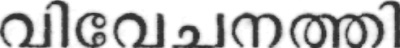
വിവേചനത്തി
